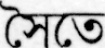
সৈতে
